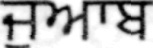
ਜੁਆਬ
